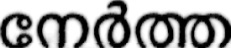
നേര്‍ത്ത
